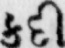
કદી
